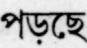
পড়ছে
